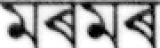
মৰমৰ
